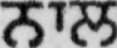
ਨਾਲ
